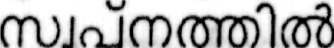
സ്വപ്നത്തില്‍
